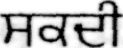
ਸਕਦੀ
